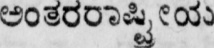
ಅಂತರರಾಷ್ಟ್ರೀಯ
